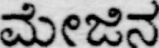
ಮೇಜಿನ
